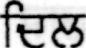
ਦਿਲ
